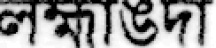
লহ্মাঙদা
